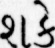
શકે
